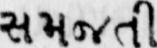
સમજતી
